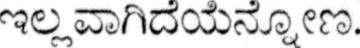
ಇಲ್ಲವಾಗಿದೆಯೆನ್ನೋಣ.
